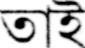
তাই
